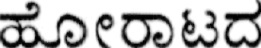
ಹೋರಾಟದ
